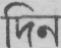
দিন
